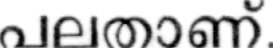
പലതാണ്.
